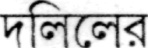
দলিলের
